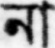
না
